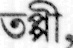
তপ্পী,
